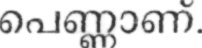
പെണ്ണാണ്.
